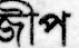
জীপ
